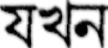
যখন
